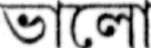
ভালো
